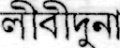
লীবীদুনা
